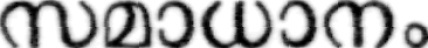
സമാധാനം
